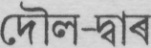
দৌল-দ্বাৰ
